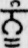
ਨੂੰ
